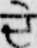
ਦੇ
